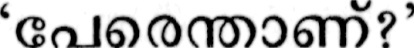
‘പേരെന്താണ്?’
